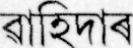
ৱাহিদাৰ
